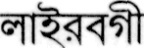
লাইরবগী
